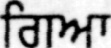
ਗਿਆ
